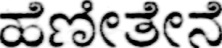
ಹೆಣೀತೇನೆ
